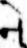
ને
